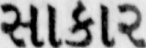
સાકાર
